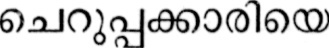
ചെറുപ്പക്കാരിയെ
